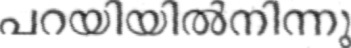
പറയിയില്‍നിന്നു
